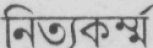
নিত্যকৰ্ম্ম
